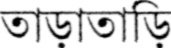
তাড়াতাড়ি
